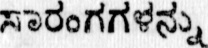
ಸಾರಂಗಗಳನ್ನು
